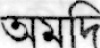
অমদি
